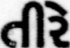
તીરે
